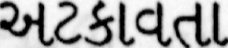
અટકાવતા
